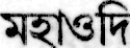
মহাওদি
